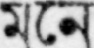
মনে
